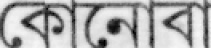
কোনোবা
